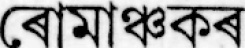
ৰোমাঞ্চকৰ
